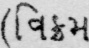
(વિક્રમ
